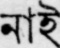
নাই
